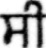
ਸੀ
